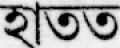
হাতত
